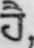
ਹੈ,
